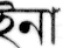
ইনা
